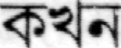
কখন
